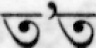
ত'ত
